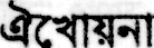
ঐখোয়না
